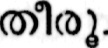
തീരൂ.
